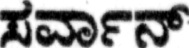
ಸರ್ವಾನ್
